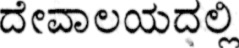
ದೇವಾಲಯದಲ್ಲಿ
